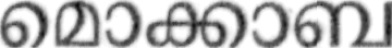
മൊക്കാബ
